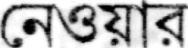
নেওয়ার
